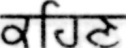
ਕਹਿਣ
